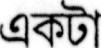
একটা
